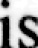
is
